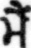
ਮੈਂ
